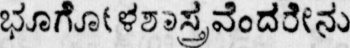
ಭೂಗೋಳಶಾಸ್ತ್ರವೆಂದರೇನು
